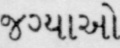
જગ્યાઓ
